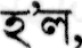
হ'ল,
